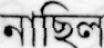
নাছিল
